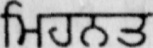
ਮਿਹਨਤ
